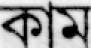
কাম
